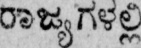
ರಾಜ್ಯಗಳಲ್ಲಿ
